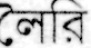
লৈরি
